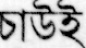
চাউই
